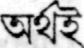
অর্থই
